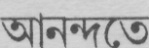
আনন্দতে
